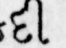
કદી
